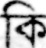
কি
